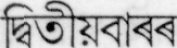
দ্বিতীয়বাৰৰ
